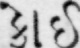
કોઈ
